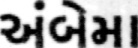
અંબેમા
